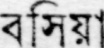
বসিয়া
